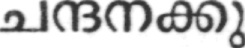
ചന്ദനക്കു
